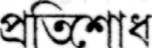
প্রতিশোধ
